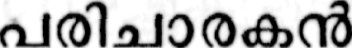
പരിചാരകന്‍
